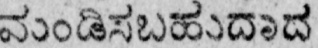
ಮಂಡಿಸಬಹುದಾದ
